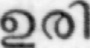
ഉരി
